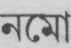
নমো
